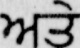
ਅਤੇ
